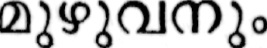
മുഴുവനും
